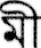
মী
